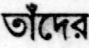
তাঁদের
